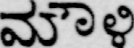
ಮೌಳಿ
